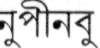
নুপীনবু
